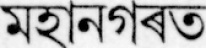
মহানগৰত
